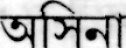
অসিনা
